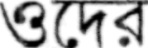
ওদের
